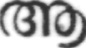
ആ
